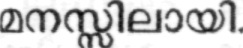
മനസ്സിലായി.
